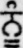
ਨੂੰ
